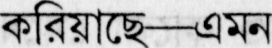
করিয়াছে-এমন
